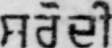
ਸਰੋਦੀ
